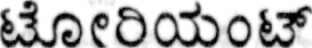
ಟೋರಿಯಂಟ್
